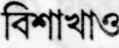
বিশাখাও
